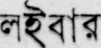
লইবার
